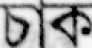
চাক
